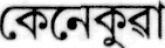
কেনেকুৱা
